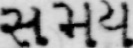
સમય
